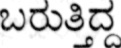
ಬರುತ್ತಿದ್ದ
